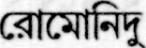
রোমোনিদু
